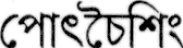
পোৎচৈশিং
